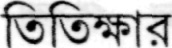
তিতিক্ষার
